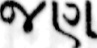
જણ
